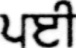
ਪਈ
